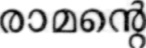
രാമന്റെ
